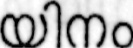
യിനം
